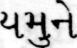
યમુને
